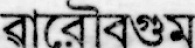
ৱারৌবগুম
